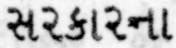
સરકારના
